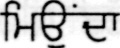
ਮਿਉਂਦਾ
